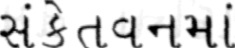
સંકેતવનમાં
